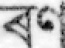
ৰণ
